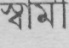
স্বামী
